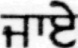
ਜਾਏ
